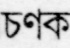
চণক
